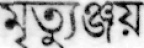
মৃত্যুঞ্জয়
